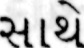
સાથે
